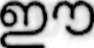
ഈ
